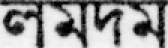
লমদম
